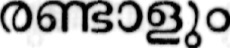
രണ്ടാളും
